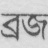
ব্ৰজ
